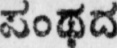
ಪಂಥದ
